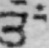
ਤੋਂ
